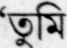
‘তুমি
